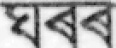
ঘৰৰ
